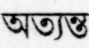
অত্যন্ত
